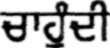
ਚਾਹੁੰਦੀ
